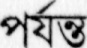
পর্যন্ত
